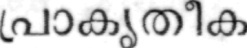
പ്രാകൃതീക
